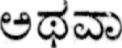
ಅಥವಾ
